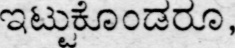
ಇಟ್ಟುಕೊಂಡರೂ,
